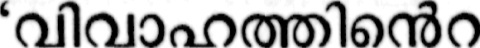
‘വിവാഹത്തിന്റെ
